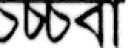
চচ্চবা
